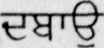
ਦਬਾਉ
